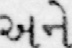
અને
